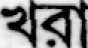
খরা
